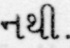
નથી.
